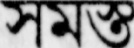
সমস্ত
